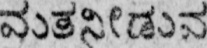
ಮತನೀಡುವ
